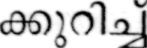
ക്കുറിച്ച്
